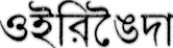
ওইরিঙৈদা
